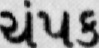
ચંપક
